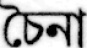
চৈনা
